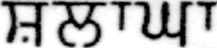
ਸ਼ਲਾਘਾ
